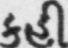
કહી
